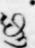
છું
